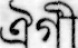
ঐগী
